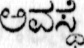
ಅವಸ್ಥೆ
